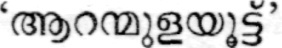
‘ആറന്മുളയൂട്ട്’
